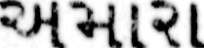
અમારા
